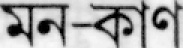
মন-কাণ
